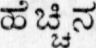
ಹೆಚ್ಚಿನ
